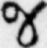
જ
